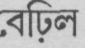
বেঢ়িল
